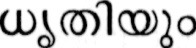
ധൃതിയും
